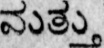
ಮತ್ತು
